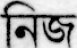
নিজ
